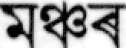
মঞ্চৰ
